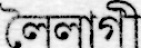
লৈলাগী
